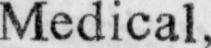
Medical,
